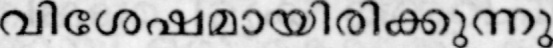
വിശേഷമായിരിക്കുന്നു
